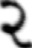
ર
